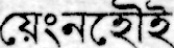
য়েংনহৌই
